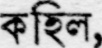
কহিল,
